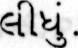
લીધું.
